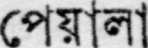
পেয়ালা
